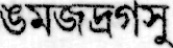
ঙমজদ্রগসু
